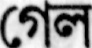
গেল
